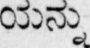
ಯನ್ನು
